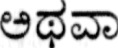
ಅಥವಾ
